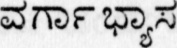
ವರ್ಗಾಭ್ಯಾಸ
